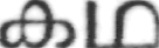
കഥ
